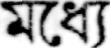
মধ্যে
